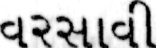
વરસાવી
